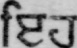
ਇਹ
